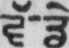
ਵੱਡੇ
